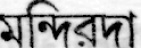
মন্দিরদা
